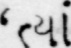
'ત્યાં
